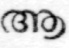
ആ
